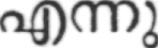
എന്നു
